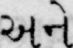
અને
